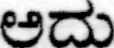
ಅದು
